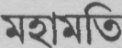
মহামতি
